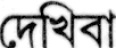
দেখিবা
